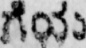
ಗೆಯ
